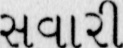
સવારી
